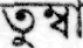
তুম্বা
